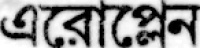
এরোপ্লেন
